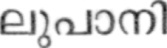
ലുപാനി
